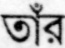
তাঁর
